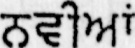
ਨਵੀਆਂ
